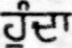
ਹੁੰਦਾ
